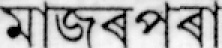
মাজৰপৰা
